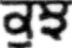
ਕੁਝ
